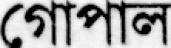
গোপাল
